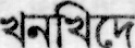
খনখিদে
